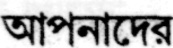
আপনাদের
